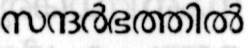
സന്ദര്‍ഭത്തില്‍
